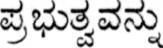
ಪ್ರಭುತ್ವವನ್ನು
